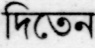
দিতেন
